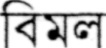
বিমল
